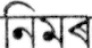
নিমৰ
